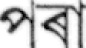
পৰা
